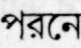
পরনে
